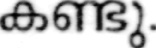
കണ്ടു.
